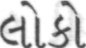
લોકો
